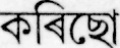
কৰিছো
